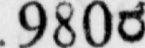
980ರ
